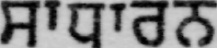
ਸਾਧਾਰਨ
